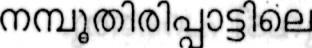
നമ്പൂതിരിപ്പാട്ടിലെ
